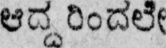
ಆದ್ದರಿಂದಲೇ
